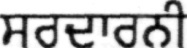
ਸਰਦਾਰਨੀ
